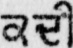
ਕਦੀ
